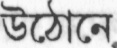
উঠোনে
